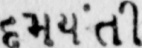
દમયંતી
